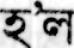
হ'ল
